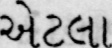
એટલા
